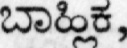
ಬಾಹ್ಲಿಕ,
